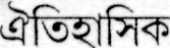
ঐতিহাসিক
